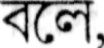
বলে,
